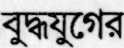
বুদ্ধযুগের
